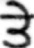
ਤੇ
